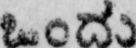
ಒಂದು
